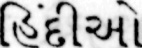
હિંદીઓ
